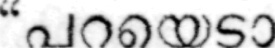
“പറയെടാ
